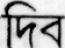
দিব
